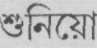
শুনিয়ো
